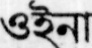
ওইনা
